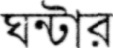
ঘন্টার
